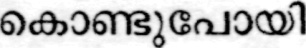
കൊണ്ടുപോയി
